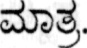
ಮಾತ್ರ.
